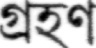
গ্রহণ
